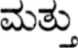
ಮತ್ತು
